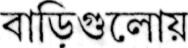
বাড়িগুলোয়
